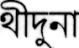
থীদুনা
